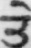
ਤੇ
